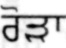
ਰੋੜਾ
